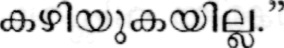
കഴിയുകയില്ല."
